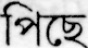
পিছে
